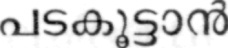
പടകൂട്ടാന്‍
